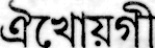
ঐখোয়গী
